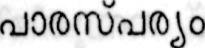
പാരസ്പര്യം
